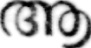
ആ
